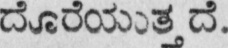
ದೊರೆಯುತ್ತದೆ.
